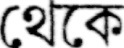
থেকে
